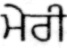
ਮੇਰੀ
